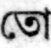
তো
